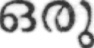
ഒരു
